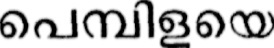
പെമ്പിളയെ
